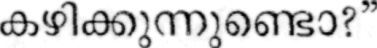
കഴിക്കുന്നുണ്ടൊ?"
